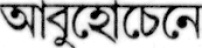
আবুহোচেনে
